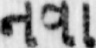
નવા
